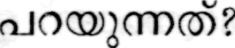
പറയുന്നത്?
